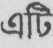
এটি
